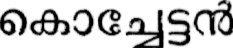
കൊച്ചേട്ടന്‍
